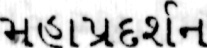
મહાપ્રદર્શન
